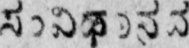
ಸಂವಿಧಾನದ
